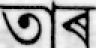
তাৰ
